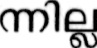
ന്നില്ല
